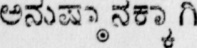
ಅನುಷ್ಠಾನಕ್ಕಾಗಿ
